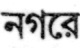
নগরে
